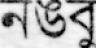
নঙবু
